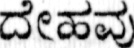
ದೇಹವು
